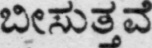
ಬೀಸುತ್ತವೆ
